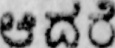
ಆದರೆ
